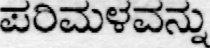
ಪರಿಮಳವನ್ನು
